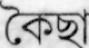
কৈছা
